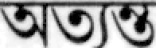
অত্যন্ত
